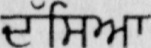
ਦੱਸਿਆ
